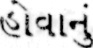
હોવાનું
